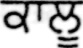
ਕਾਲੂ
